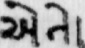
એનો
